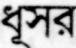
ধূসর
